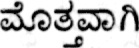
ಮೊತ್ತವಾಗಿ
